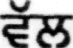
ਵੱਲ
